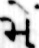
મેં
